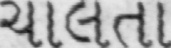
ચાલતા
